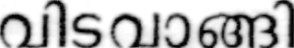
വിടവാങ്ങി
